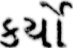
કર્યો
